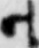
ન
